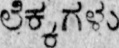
ಲೆಕ್ಕಗಳು
